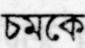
চমকে
